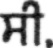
ਸੀ,
